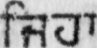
ਜਿਹਾ
